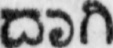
ದಾಗಿ
